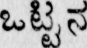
ಒಟ್ಟಿನ
